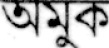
অমুক
